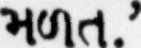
મળત.'
